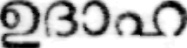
ഉദാഹ
